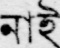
নাই
